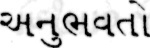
અનુભવતો
